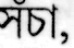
সঁচা,
